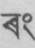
ৰং
